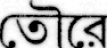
তৌরে
